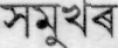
সমুখৰ
